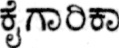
ಕೈಗಾರಿಕಾ
